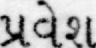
પ્રવેશ
